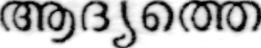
ആദ്യത്തെ
